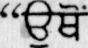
''ਉਥੋਂ
